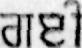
ਗਈ
